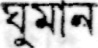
ঘুমান
